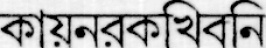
কায়নরকখিবনি
